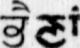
ਭੈਣਾਂ
